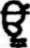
ਊਂ
